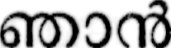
ഞാന്‍
